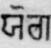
ਯੋਗ
